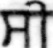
ਸੀ
